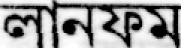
লানফম
